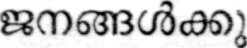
ജനങ്ങള്‍ക്കു
